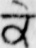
ਕੇ
